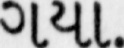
ગયા.
